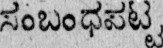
ಸಂಬಂಧಪಟ್ಟೆ
